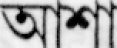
আশা
